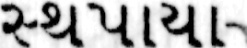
સ્થપાયા
